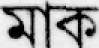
মাক
